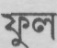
ফুল
